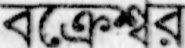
বক্রেশ্বর
